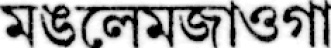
মঙলেজাওগা
